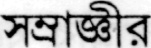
সম্রাজ্ঞীর
